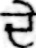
ਦੇ
